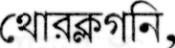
থোরক্লগনি,
